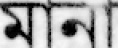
মানা
